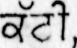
ਕੱਟੀ,
